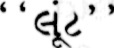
"લૂંટ"
